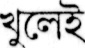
খুলেই
